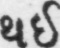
થઈ
